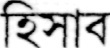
হিসাব
